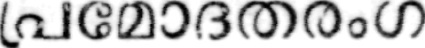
പ്രമോദതരംഗ
